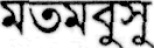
মতমবুসু
